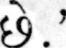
છે.'
